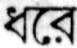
ধরে
